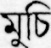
মুচি
